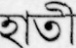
হাতী
